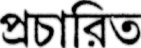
প্রচারিত
